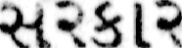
સરકાર
